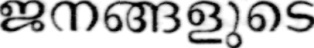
ജനങ്ങളുടെ
